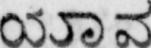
ಯಾವ
